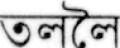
তললৈ
